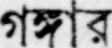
গঙ্গার
